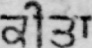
ਕੀਤਾ
